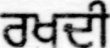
ਰਖਦੀ
